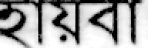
হায়বা
